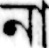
না
